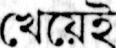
খেয়েই
